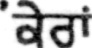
'ਕੇਰਾਂ
